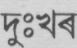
দুঃখৰ
